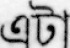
এটা
